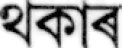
থকাৰ
